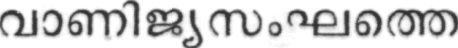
വാണിജ്യസംഘത്തെ
